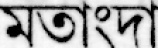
মতাংদা
